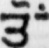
ਤੋਂ
